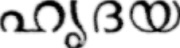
ഹൃദയ
